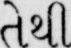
તેથી
